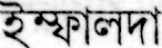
ইম্ফালদা
